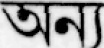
অন্য
